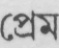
প্ৰেম
